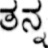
ತನ್ನ
